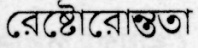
রেষ্টোরোন্ততা
